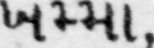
ખમ્મા,
